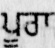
ਪੂਰਾ
